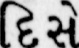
દિસે
